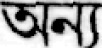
অন্য
